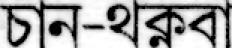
চান-থক্নবা
